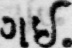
ગઈ.
